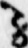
કે
